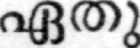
ഏതു
